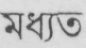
মধ্যত
